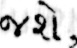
જશે,
